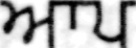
ਆਪ
